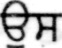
ਉਸ
